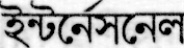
ইন্টর্নেসনেল
